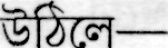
উঠিলে-
